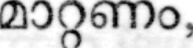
മാറ്റണം,
